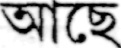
আছে
